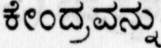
ಕೇಂದ್ರವನ್ನು
